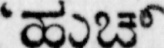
‘ಹುಚ್
